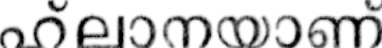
ഹ്ലാനയാണ്
